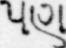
પણ
